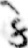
કે
